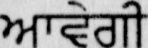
ਆਵੇਗੀ
